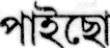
পাইছো
